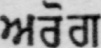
ਅਰੋਗ
